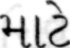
માટે
